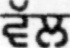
ਵੱਲ
